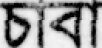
চাবা
